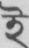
ই
